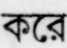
করে
